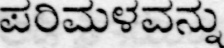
ಪರಿಮಳವನ್ನು
